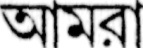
আমরা
